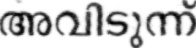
അവിടുന്ന്
